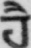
ਹੈ
